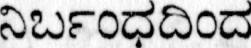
ನಿರ್ಬಂಧದಿಂದ
